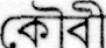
কৌবী
